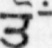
ਤੋਂ
